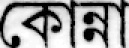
কোন্না
